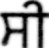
ਸੀ
